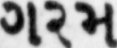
ગરમ
